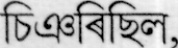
চিঞৰিছিল,
